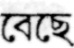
বেছে
